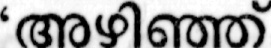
‘അഴിഞ്ഞ്
